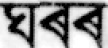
ঘৰৰ
